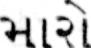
મારો
